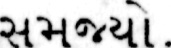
સમજ્યો.
